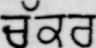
ਚੱਕਰ
